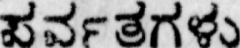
ಪರ್ವತಗಳು
